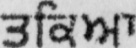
ਤਕਿਆ
